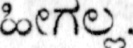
ಹೀಗಲ್ಲ.
